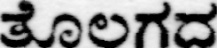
ತೊಲಗದ
